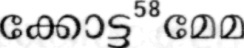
ക്കോട്ട58മേമ
